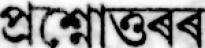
প্রশ্নোত্তৰৰ
